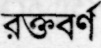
রক্তবর্ণ
